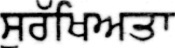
ਸੁਰੱਖਿਅਤਾ
